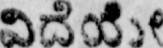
ವಿದೆಯೇ
